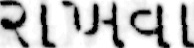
રાખવા
